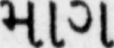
માગ
